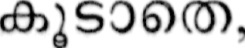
കൂടാതെ,
